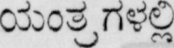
ಯಂತ್ರಗಳಲ್ಲಿ
